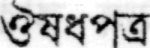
ঔষধপত্র
